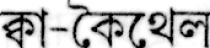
ক্বা-কৈথেল
